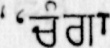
''ਚੰਗਾ
